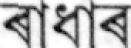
ৰাধাৰ
